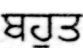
ਬਹੁਤ
